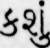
કશું
